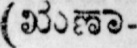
(ಋಣಾ-
